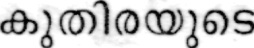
കുതിരയുടെ
